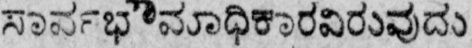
ಸಾರ್ವಭೌಮಾಧಿಕಾರವಿರುವುದು
